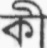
কী
